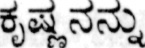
ಕೃಷ್ಣನನ್ನು
